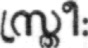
സ്ത്രീ:
